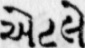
એટલે
